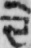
ਦੇ
